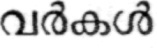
വര്‍കള്‍
